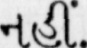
નહીં.
